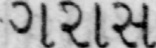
ગરાસ
